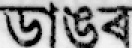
ডাঙৰ
